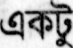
একটু
